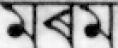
মৰম
